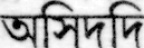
অসিদদি
